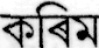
কৰিম
